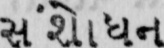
સંશોધન
